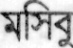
মসিবু
